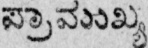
ಪ್ರಾಮುಖ್ಯ
